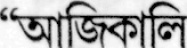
"আজিকালি
